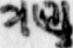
ત્રણ
